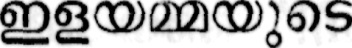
ഇളയമ്മയുടെ
